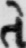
તે
